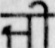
ਜੀ
